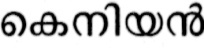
കെനിയന്‍
